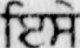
ਇਸੇ
